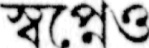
স্বপ্নেও
